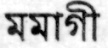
মমাগী
